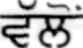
ਵੱਲੋਂ
